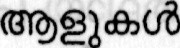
ആളുകള്‍
